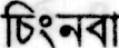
চিংনবা
